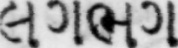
લગભગ
